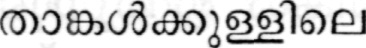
താങ്കള്‍ക്കുള്ളിലെ
